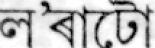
ল'ৰাটো
